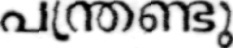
പന്ത്രണ്ടു
